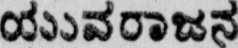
ಯುವರಾಜನ
